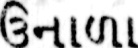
ઉનાળા
